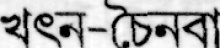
খৎন-চৈনবা
